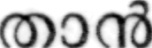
താന്‍
